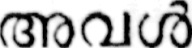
അവള്‍
